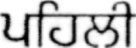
ਪਹਿਲੀ
